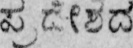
ಪ್ರದೇಶದ
